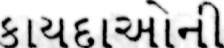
કાયદાઓની
